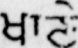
ਖਾਣੇ
